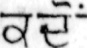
ਕਦੋਂ
